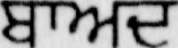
ਬਾਅਦ
